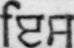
ਇਸ
